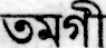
তমগী
